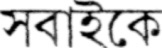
সবাইকে
